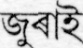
জুৰাই
